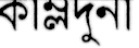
কাম্লদুনা
